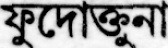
ফুদোক্তুনা
